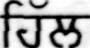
ਹਿੱਲ
